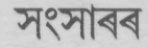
সংসাৰৰ
